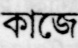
কাজে
